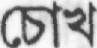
চোখ
